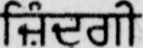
ਜ਼ਿੰਦਗੀ
